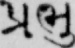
પ્રભુ
